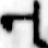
ન
